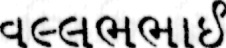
વલ્લભભાઈ
